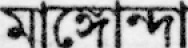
মাঙ্গোন্দা
